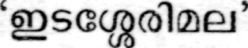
‘ഇടശ്ശേരിമല’
